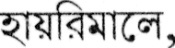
হায়রিমালে,
